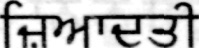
ਜ਼ਿਆਦਤੀ
